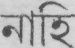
নাহি
